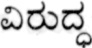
ವಿರುದ್ಧ
